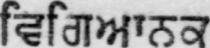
ਵਿਗਿਆਨਕ
